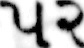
પર
